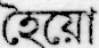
হৈয়ো
